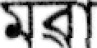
মৱা
